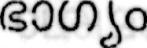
ഭാഗ്യം
